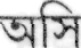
অসি
